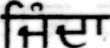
ਜਿੰਦਾ
